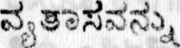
ವ್ಯತಾಸವನ್ನು
